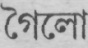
গৈলো
